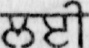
ਲਈ
